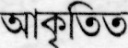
আকৃতিত
